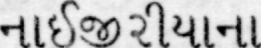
નાઈજીરીયાના
